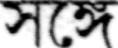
সঙ্গে
